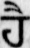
ਹੈ
